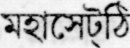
মহাসেট্ঠি
